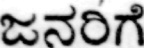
ಜನರಿಗೆ
